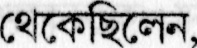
থেকেছিলেন,
